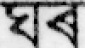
ঘৰ
